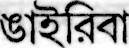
ঙাইরিবা
